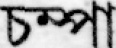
চম্পা
